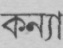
কন্যা
